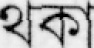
থকা
